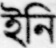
ইনি
